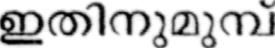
ഇതിനുമുമ്പ്
